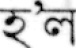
হ'ল
